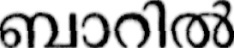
ബാറില്‍
